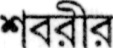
শবরীর
